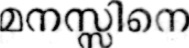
മനസ്സിനെ
